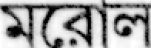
মরোল
